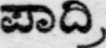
ಪಾದ್ರಿ
